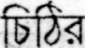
চিঠির
